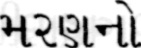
મરણનો
